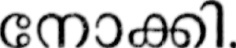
നോക്കി.
